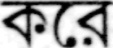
করে
